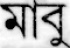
মাবু
